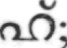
ഹ്;
